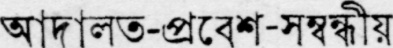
আদালত-প্রবেশ-সম্বন্ধীয়
